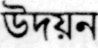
উদয়ন
